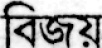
বিজয়
